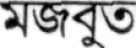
মজবুত
